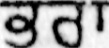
ਭਰਾ
